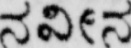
ನವೀನ
